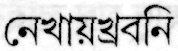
নেখায়খ্রবনি
